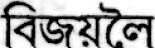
বিজয়লৈ
